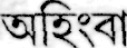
অহিংবা
